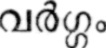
വര്‍ഗ്ഗം
